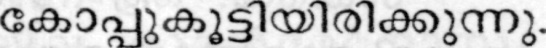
കോപ്പുകൂട്ടിയിരിക്കുന്നു.
